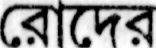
রোদের
